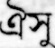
ঐসু
